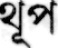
থূপ
